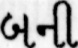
બની
